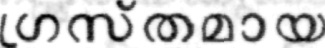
ഗ്രസ്തമായ
